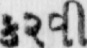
કરવી
